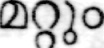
മറ്റും
